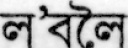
ল'বলৈ
